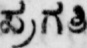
ಪ್ರಗತಿ
